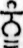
ਨੂੰ
